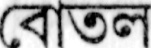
বোতল
